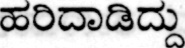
ಹರಿದಾಡಿದ್ದು
